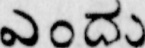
ಎಂದು
